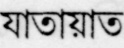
যাতায়াত
